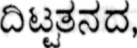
ದಿಟ್ಟತನದ,
